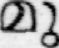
മു
